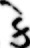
કે
